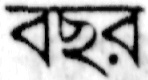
বছর
